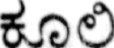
ಕೂಲಿ
